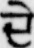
ਦੇ
